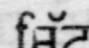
ਸਿੱਟ
